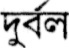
দুর্বল
